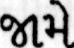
જામે
